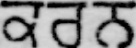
ਕਰਨ
